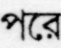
পরে
